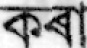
কৰা
